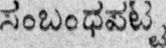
ಸಂಬಂಧಪಟ್ಟ
